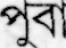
পুবা
